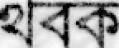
থবক
